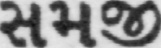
સમજી
